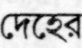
দেহের
